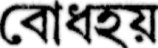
বোধহয়
